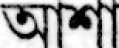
আশা
